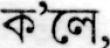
ক'লে,
